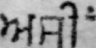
ਅਸੀਂ
